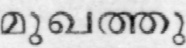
മുഖത്തു
